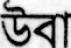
উবা
